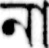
না
